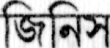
জিনিস
